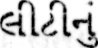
લીટીનું
